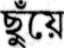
ছুঁয়ে
